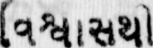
વિશ્વાસથી
